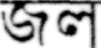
জল
